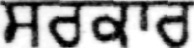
ਸਰਕਾਰ
